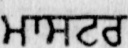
ਮਾਸਟਰ
